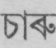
চাৰু
